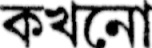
কখনো
